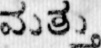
ಮತ್ತು
